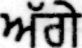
ਅੱਗੇ
